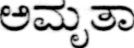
ಅಮೃತಾ
